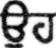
ਉਹ
